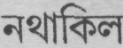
নথাকিল
